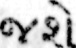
જશે
